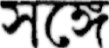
সঙ্গে
